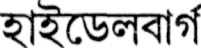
হাইডেলবার্গ
